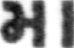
મા
